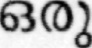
ഒരു
